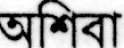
অশিবা
